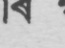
পৰ
